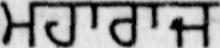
ਮਹਾਰਾਜ
